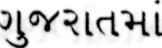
ગુજરાતમાં
